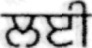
ਲਈ
